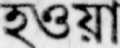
হওয়া
